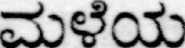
ಮಳೆಯ
